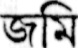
জমি
